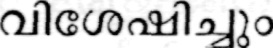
വിശേഷിച്ചും
